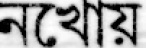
নখোয়
